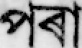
পৰা
